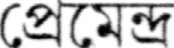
প্রেমেন্দ্র
